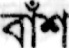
বাঁশ
